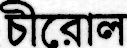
চীরোল
